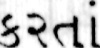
કરતાં
